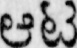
ಆಟ
